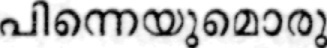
പിന്നെയുമൊരു
